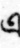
এ
